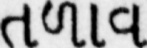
તળાવ
